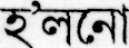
হ'লনো
